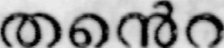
തന്റെ
